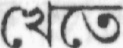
খেতে
